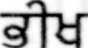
ਭੀਖ
